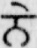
ਨੇ
